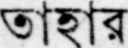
তাহার
